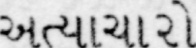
અત્યાચારો
